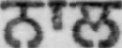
ਨਾਲ
